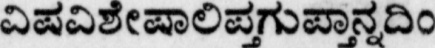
ವಿಷವಿಶೇಷಾಲಿಪ್ತಗುಪ್ತಾನ್ನದಿಂ
